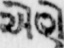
એણે
